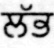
ਲੱਭ
